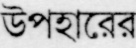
উপহারের
